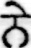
ਨੇ
